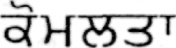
ਕੋਮਲਤਾ
